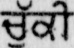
ਚੁੱਕੀ
